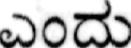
ಎಂದು
